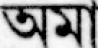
অমা
